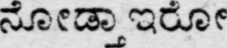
ನೋಡ್ತಾಇರೋ
